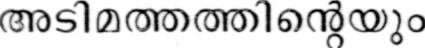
അടിമത്തത്തിന്റെയും
